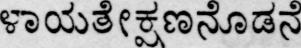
ಳಾಯತೇಕ್ಷಣನೊಡನೆ
